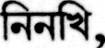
নিনখি,
